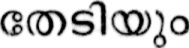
തേടിയും
